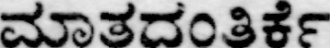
ಮಾತದಂತಿರ್ಕೆ
